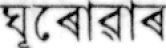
ঘূৰোৱাৰ
